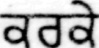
ਕਰਕੇ
